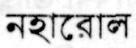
নহারোল
